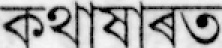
কথাষাৰত
